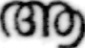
ആ
